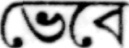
ভেবে
